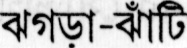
ঝগড়া-ঝাঁটি
